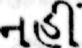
નહીં
